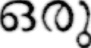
ഒരു
